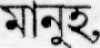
মানুহ,
